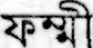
ফম্মী
